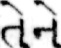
તેને
